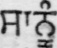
ਸਾਨੂੰ
